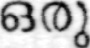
ഒരു
